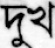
দুখ
